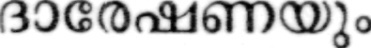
ദാരേഷണയും
